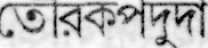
তৌরকপদুদা
